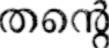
തന്റെ
